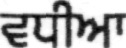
ਵਧੀਆ
